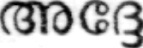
അദ്ദേ
